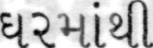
ઘરમાંથી
